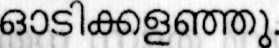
ഓടിക്കളഞ്ഞു.
